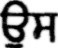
ਉਸ
